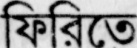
ফিরিতে
